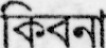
কিবনা
